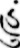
હું
